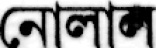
নোলাল
